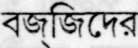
বজ্জিদের
